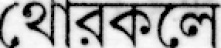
থোরকলে
